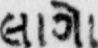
લાગો
